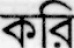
করি
